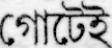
গোটেই
